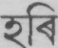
হৰি
